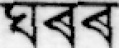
ঘৰৰ
